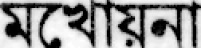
মখোয়না
